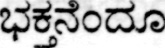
ಭಕ್ತನೆಂದೂ
